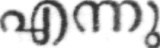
എന്നു
